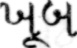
ખૂબ
